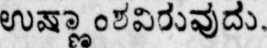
ಉಷ್ಣಾಂಶವಿರುವುದು.
